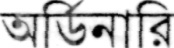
অর্ডিনারি
